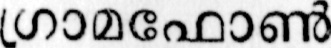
ഗ്രാമഫോണ്‍
